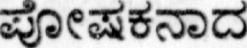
ಪೋಷಕನಾದ
